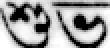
শুভ
